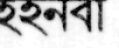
ইহনবা
